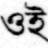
ওই
